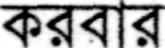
করবার
